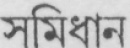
সমিধান
